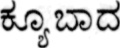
ಕ್ಯೂಬಾದ
